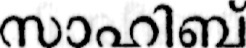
സാഹിബ്
